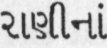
રાણીનાં
